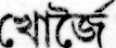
খোর্জৈ
